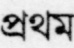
প্রথম
